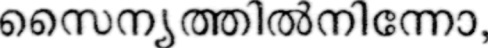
സൈന്യത്തില്‍നിന്നോ,
